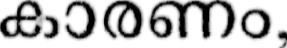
കാരണം,
